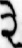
રે
